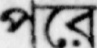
পরে
